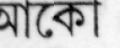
আকৌ
